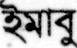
ইমাবু
